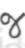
જ
